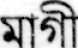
মাগী
